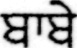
ਬਾਬੇ
